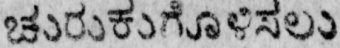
ಚುರುಕುಗೊಳಿಸಲು
